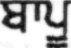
ਬਾਪੂ
